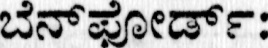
ಬೆನ್‌ಫೋರ್ಡ್:
